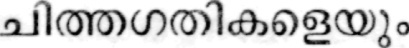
ചിത്തഗതികളെയും
